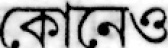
কোনেও
